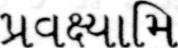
પ્રવક્ષ્યામિ
